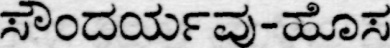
ಸೌಂದರ್ಯವು-ಹೊಸ
